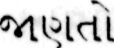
જાણતો
